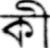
কী
